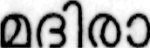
മദിരാ
